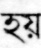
হয়
